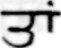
ਤਾਂ
